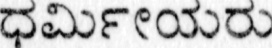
ಧರ್ಮೀಯರು
